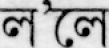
ল'লে
